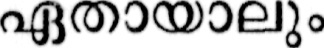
ഏതായാലും
